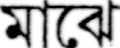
মাঝে
